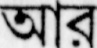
আর
